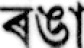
ৰঙা
